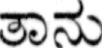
ತಾನು
